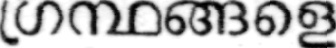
ഗ്രന്ഥങ്ങളെ
